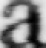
a
